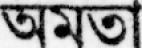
অমতা
